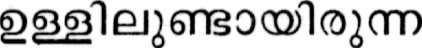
ഉള്ളിലുണ്ടായിരുന്ന
